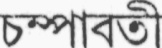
চম্পাবতী
